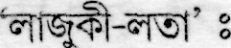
'লাজুকী-লতা'ঃ
